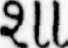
શા
